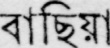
বাছিয়া
